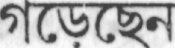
গড়েছেন
